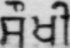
ਸੌਖੀ
